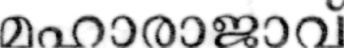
മഹാരാജാവ്
